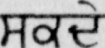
ਸਕਦੇ
